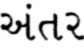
અંતર
